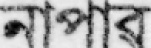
নাপাৱ
